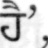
ਹੈ',
